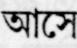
আসে
